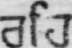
ਰਹਿ
